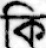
কি
